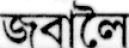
জবালৈ
